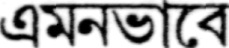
এমনভাবে
